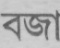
বজা
